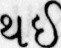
થઈ
